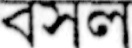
বসল
